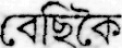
বেছিকৈ
